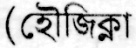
(হৌজিক্না
